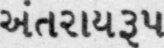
અંતરાયરૂપ
